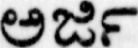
ಅರ್ಜಿ
